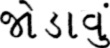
જોડાવું
